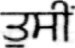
ਤੁਸੀਂ
